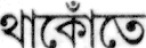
থাকোঁতে
